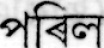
পৰিল
